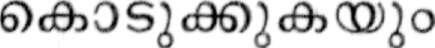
കൊടുക്കുകയും
